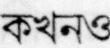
কখনও
